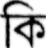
কি
